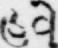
હવે
